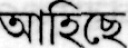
আহিছে
